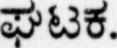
ಘಟಕ.
